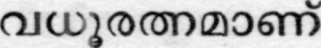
വധൂരത്നമാണ്
